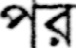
পর
